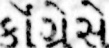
કૉંગ્રેસે
